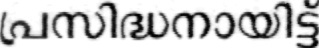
പ്രസിദ്ധനായിട്ട്
